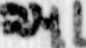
આ
